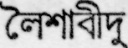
লৈশাবীদু
